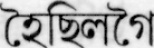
হৈছিলগৈ
